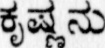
ಕೃಷ್ಣನು
